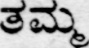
ತಮ್ಮ
